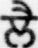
ਲੈ
